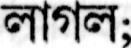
লাগল;
